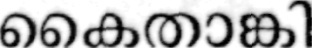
കൈതാങ്കി
